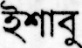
ইশাবু
